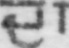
ਦਾ
